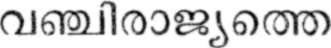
വഞ്ചിരാജ്യത്തെ
